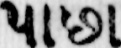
પાછા
